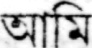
আমি
